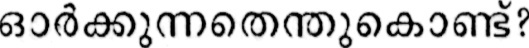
ഓര്‍ക്കുന്നതെന്തുകൊണ്ട്?
